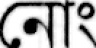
নোং
